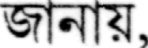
জানায়,
